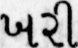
ખરી
